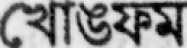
খোঙফম
